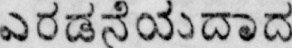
ಎರಡನೆಯದಾದ
